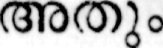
അതും
